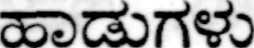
ಹಾಡುಗಳು
